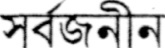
সর্বজনীন
